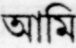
আমি
